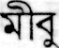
মীবু
